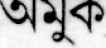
অমুক
